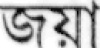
জয়া
